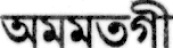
অমমতগী
